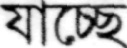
যাচ্ছে
